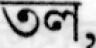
তল,
